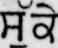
ਸੁੱਕੇ
